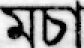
মচা
